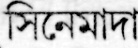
সিনেমাদা
